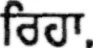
ਰਿਹਾ,
